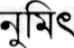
নুমিৎ
